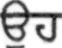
ਉਹ
